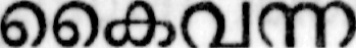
കൈവന്ന
